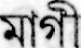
মাগী
